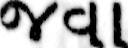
જવા
